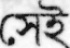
সেই
